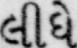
લીધે
